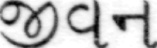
જીવન
